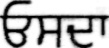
ਓਸਦਾ
